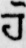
ਹੋ
